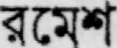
রমেশ
